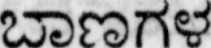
ಬಾಣಗಳ
